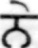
ਨੇ
